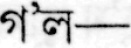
গ'ল-
